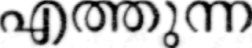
എത്തുന്ന
